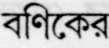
বণিকের
